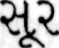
સૂર
